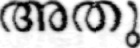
അതു
